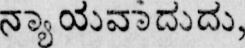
ನ್ಯಾಯವಾದುದು,
